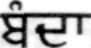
ਬੰਦਾ
